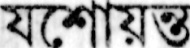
যশোয়ন্ত
